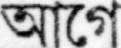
আগে
